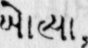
બોલ્યા,
